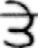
ਤੇ
